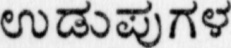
ಉಡುಪುಗಳ
